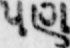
પણ
